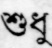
শুধু
